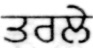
ਤਰਲੇ
